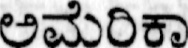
ಅಮೆರಿಕಾ
